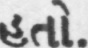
હતો.
